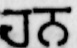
ਹਨ
